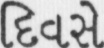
દિવસે
